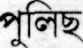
পুলিছ
